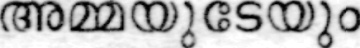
അമ്മയുടേയും
